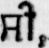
ਸੀ,
